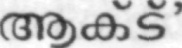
ആക്ട്'
